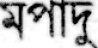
মপাদু
